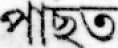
পাছত
